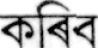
কৰিব
